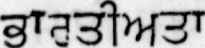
ਭਾਰਤੀਅਤਾ
